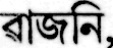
ৱাজনি,
